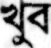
খুব
